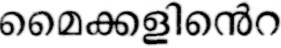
മൈക്കളിന്റെ
